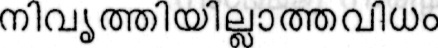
നിവൃത്തിയില്ലാത്തവിധം
